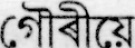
গৌৰীয়ে
